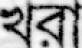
খরা
